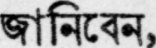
জানিবেন,
